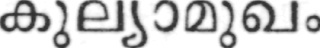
കുല്യാമുഖം
